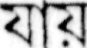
যায়
